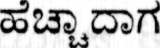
ಹೆಚ್ಚಾದಾಗ
